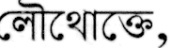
লৌথোক্তনা,
